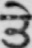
ਤੇ
